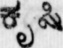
ಕೃಷಿ
